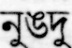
নুঙদু
